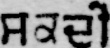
ਸਕਦੀ
